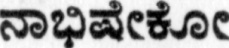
ನಾಭಿಷೇಕೋ
